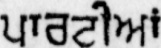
ਪਾਰਟੀਆਂ
